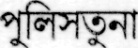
পুলিসতুনা
